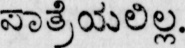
ಪಾತ್ರೆಯಲಿಲ್ಲ.
